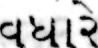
વધારે
